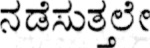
ನಡೆಸುತ್ತಲೇ
